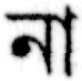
না
